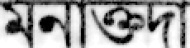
মনাক্তদা
